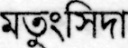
মতুংসিদা
